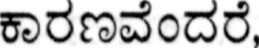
ಕಾರಣವೆಂದರೆ,
